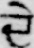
ਦੇ
